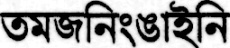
তমজনিংঙাইনি
